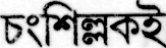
চংশিল্লকই
